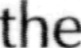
the
